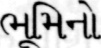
ભૂમિનો
